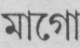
মাগো
